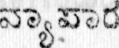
ವ್ಯಾಪಾರ
